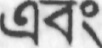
এবং
